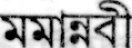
মমান্নবী
